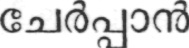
ചേര്‍പ്പാന്‍
